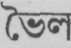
ভৈল
